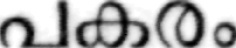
പകരം
